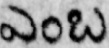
ಎಂಬ
